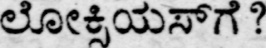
ಲೋಕ್ಸಿಯಸ್ಗೆ?
